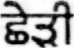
ਛੇੜੀ
